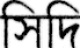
সিদি
